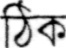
ঠিক
